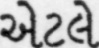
એટલે
